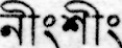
নীংশীং
